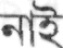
নাই
